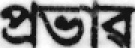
প্ৰভাৱ
